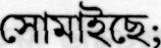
সোমাইছে;
